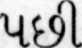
પછી
